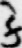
કે
